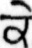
ਕੇ
